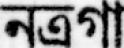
নত্রগা
